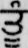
ਤੂੰ
